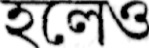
হলেও
